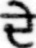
ਦੇ
